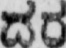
ದರ
